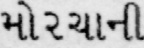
મોરચાની
